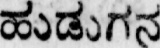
ಹುಡುಗನ
